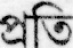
প্রতি
